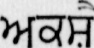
ਅਕਸ਼ੈ
